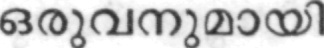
ഒരുവനുമായി
